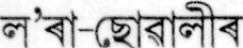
ল'ৰা-ছোৱালীৰ
